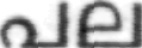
പല
